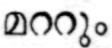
മററും
